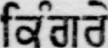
ਕਿੰਗਰੇ
